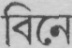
বিনে
